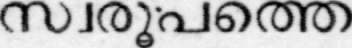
സ്വരൂപത്തെ
